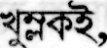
খুম্লকই,
